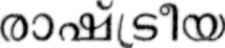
രാഷ്ട്രീയ
